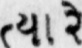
ત્યારે
